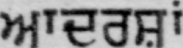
ਆਦਰਸ਼ਾਂ
